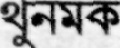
থুনমক
